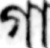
গা
